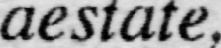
aestate,
